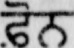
ਫ਼ੋਨ
